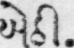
એઠી.
